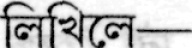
লিখিলে-
